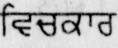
ਵਿਚਕਾਰ
